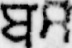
ਬਸ
